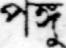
পঙ্গু
